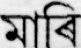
মাৰি
